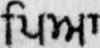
ਪਿਆ
